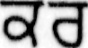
ਕਰ
